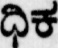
ಧಿಕ
